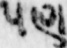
પણ
